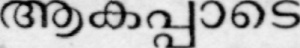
ആകപ്പാടെ
